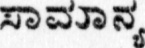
ಸಾಮಾನ್ಯ
